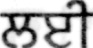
ਲਈ
